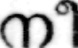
നീ
